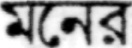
মনের
